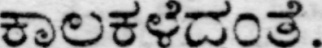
ಕಾಲಕಳೆದಂತೆ.
